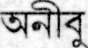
অনীবু
